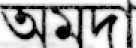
অমদা
